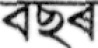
বছৰ
